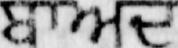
ਬਾਅਦ
